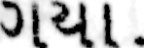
ગયા.
